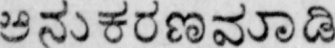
ಅನುಕರಣಮಾಡಿ
